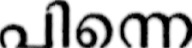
പിന്നെ
